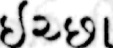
ઇચ્છા
